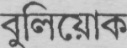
বুলিয়োক
